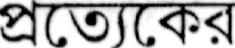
প্রত্যেকের
